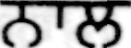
ਨਾਲ
